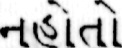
નહોતો
